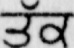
ਤੱਕ
